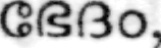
ഭേദം,
